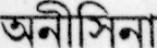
অনীসিনা
